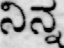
ನಿನ್ನ
